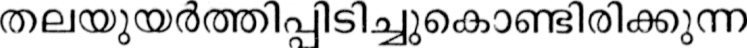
തലയുയര്‍ത്തിപ്പിടിച്ചുകൊണ്ടിരിക്കുന്ന
